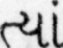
ત્યાં
